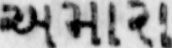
અમારા
